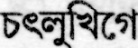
চৎলুখিগে
